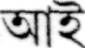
আই
